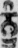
ਨੂੰ
